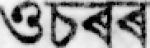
ওচৰৰ
